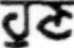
ਹੁਣ
